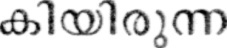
കിയിരുന്ന
